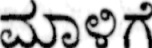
ಮಾಳಿಗೆ
